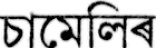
চামেলিৰ
